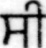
ਸੀ
